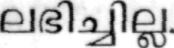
ലഭിച്ചില്ല.
